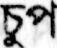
চুপ
